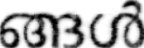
ങ്ങള്‍
